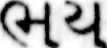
ભય
